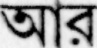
আর
